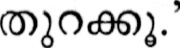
തുറക്കൂ.’
